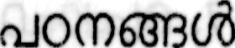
പഠനങ്ങള്‍
